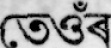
তেওঁৰ
